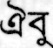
ঐবু
